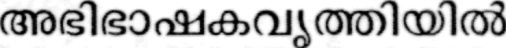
അഭിഭാഷകവൃത്തിയില്‍
